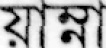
য়াম্না
